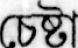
চেষ্টা
